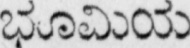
ಭೂಮಿಯ
